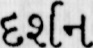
દર્શન
